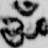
ૐ
